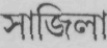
সাজিলা
